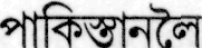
পাকিস্তানলৈ
